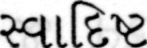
સ્વાદિષ્ટ
